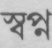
স্বপ্ন
